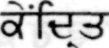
ਕੇਂਦ੍ਰਿਤ
